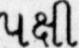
પક્ષી
